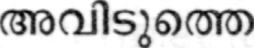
അവിടുത്തെ
